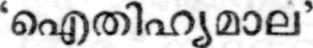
‘ഐതിഹ്യമാല’
